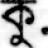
কু.
